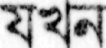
যখন
